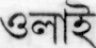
ওলাই
